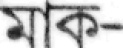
মাক-
